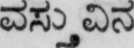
ವಸ್ತುವಿನ
